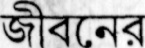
জীবনের
